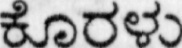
ಕೊರಳು
